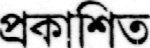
প্রকাশিত
